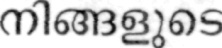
നിങ്ങളുടെ
